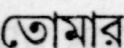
তোমার
